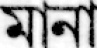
মানা
